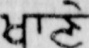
ਖਾਣੇ
